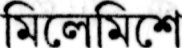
মিলেমিশে
